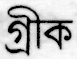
গ্রীক
